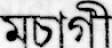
মচাগী
